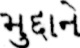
મુદ્દાને
